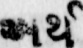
અર્થ
